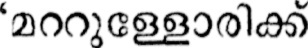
‘മററുള്ളോരിക്ക്
